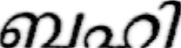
ബഹി
